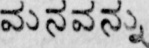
ಮನವನ್ನು
